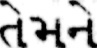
તેમને
